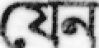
যেন
